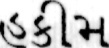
હકીમ
